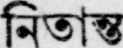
নিতান্ত
